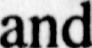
and
